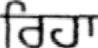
ਰਿਹਾ
